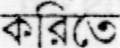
করিতে
